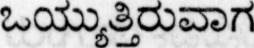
ಒಯ್ಯುತ್ತಿರುವಾಗ
